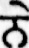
ਨੇ
